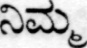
ನಿಮ್ಮ
